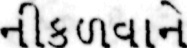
નીકળવાને
